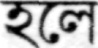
হলে
